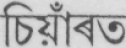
চিয়াঁৰত
